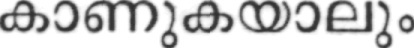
കാണുകയാലും
